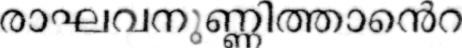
രാഘവനുണ്ണിത്താന്റെ
